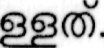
ള്ളത്.
